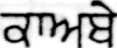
ਕਾਅਬੇ
